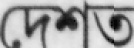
দেশত
